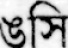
ঙসি
